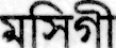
মসিগী
